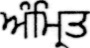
ਅੰਮ੍ਰਿਤ
